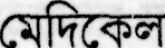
মেদিকেল
